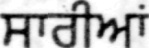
ਸਾਰੀਆਂ
